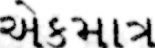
એકમાત્ર
